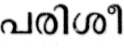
പരിശീ
